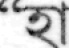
“হা
